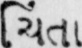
ચિંતા
